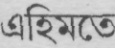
এহিমতে
